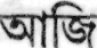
আজি
